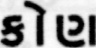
કોણ
